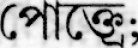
পোক্ত্রে;
